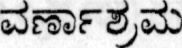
ವರ್ಣಾಶ್ರಮ
